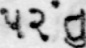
પરંતુ
